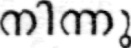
നിന്നു
